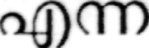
എന്ന
